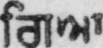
ਗਿਆ
